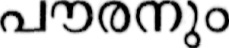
പൌരനും
